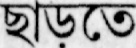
ছাড়তে
